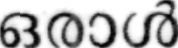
ഒരാള്‍
